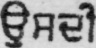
ਉਸਦੀ
